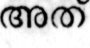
അത്
